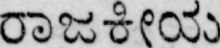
ರಾಜಕೀಯ
